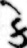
કે
